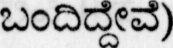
ಬಂದಿದ್ದೇವೆ)
